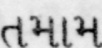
તમામ
